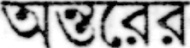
অন্তরের
